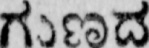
ಗುಣದ
